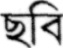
ছবি
